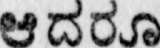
ಆದರೂ
